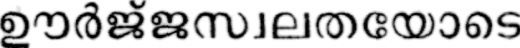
ഊര്‍ജ്ജസ്വലതയോടെ
